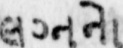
લગ્નનો
